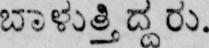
ಬಾಳುತ್ತಿದ್ದರು.
